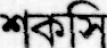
শকসি
